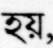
হয়,
